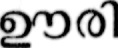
ഊരി
